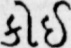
કોઈ
